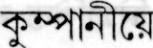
কুম্পানীয়ে
